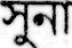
সুনা
